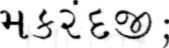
મકરંદજી;
